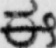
ಈ
